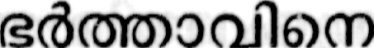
ഭര്‍ത്താവിനെ
